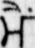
ਮੈਂ
